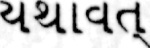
યથાવત્
